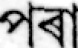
পৰা
